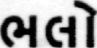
ભલો
